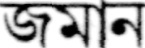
জমান
